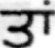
ਤਾਂ
